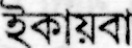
ইকায়বা
